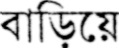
বাড়িয়ে
